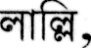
লাল্লি,
